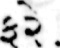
ફરે.
